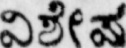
ವಿಶೇಷ
